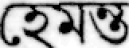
হেমন্ত
